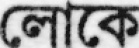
লোকে
